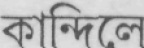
কান্দিলে
